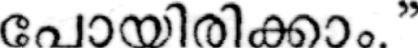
പോയിരിക്കാം."
